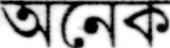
অনেক
